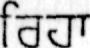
ਰਿਹਾ
